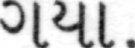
ગયા.
